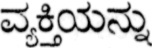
ವ್ಯಕ್ತಿಯನ್ನು
